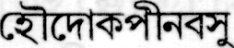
হৌদোকপীনবসু
